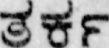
ತರ್ಕ
